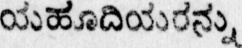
ಯಹೂದಿಯರನ್ನು
